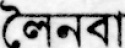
লৈনবা
